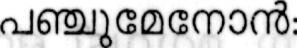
പഞ്ചുമേനോന്‍:
